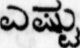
ಎಷ್ಟು
